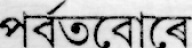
পর্বতবোৰে
